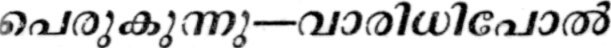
പെരുകുന്നു-വാരിധിപോല്‍
